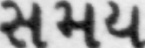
સમય
